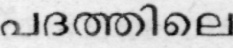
പദത്തിലെ
